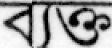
ব্যক্ত
